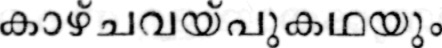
കാഴ്ചവയ്പുകഥയും
